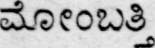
ಮೋಂಬತ್ತಿ
